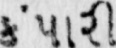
કંપારી
